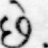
છે.
